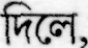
দিলে,
